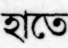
হাতে
